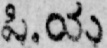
ಪಿ.ಯ
